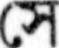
সে
